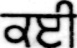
ਕਈ
